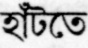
হাঁটতে
